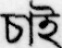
চাই
